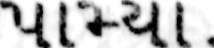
પામ્યા.
